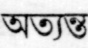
অত্যন্ত
